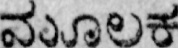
ಮೂಲಕ
